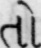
તો
